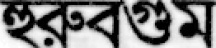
হুরুবগুম
